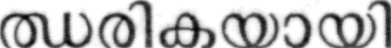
ഝരികയായി
